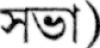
সভা)
